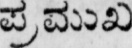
ಪ್ರಮುಖ
